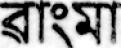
ৱাংমা
